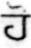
ਹੋ
